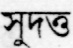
সুদত্ত
